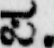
ಪ.
